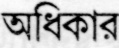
অধিকার
